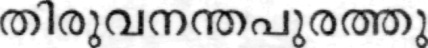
തിരുവനന്തപുരത്തു
